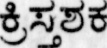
ಕ್ರಿಸ್ತಶಕ
